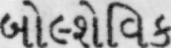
બોલ્શેવિક
